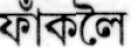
ফাঁকলৈ
